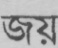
জয়
